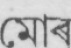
মোৰ
